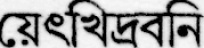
য়েৎখিদ্রবনি
